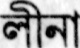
লীনা
